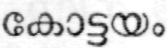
കോട്ടയം
